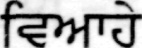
ਵਿਆਹੇ
